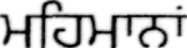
ਮਹਿਮਾਨਾਂ
